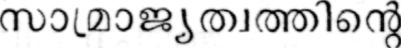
സാമ്രാജ്യത്വത്തിന്റെ
